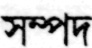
সম্পদ
